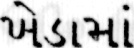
ખેડામાં
